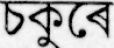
চকুৰে
